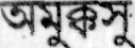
অমুক্কসু
